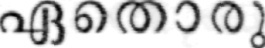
ഏതൊരു
